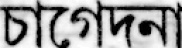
চাগেদনা
